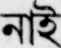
নাই
